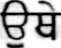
ਉਥੇ
